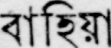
বাহিয়া
